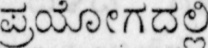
ಪ್ರಯೋಗದಲ್ಲಿ
